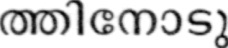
ത്തിനോടു
